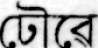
ঢৌৱে
